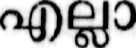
എല്ലാ
